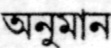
অনুমান
